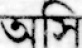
অসি
